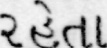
રહેતા
